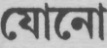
যোনো
